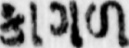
કાગળ
